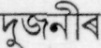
দুজনীৰ
